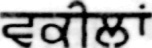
ਵਕੀਲਾਂ
